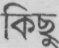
কিছু
